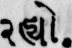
રહ્યો.
